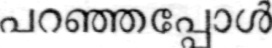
പറഞ്ഞപ്പോള്‍
